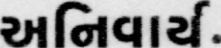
અનિવાર્ય.
